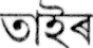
তাইৰ
